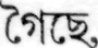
গৈছে,
